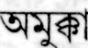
অমুক্কা
